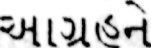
આગ્રહને
